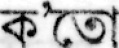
ক'তো
